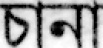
চানা
